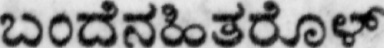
ಬಂದೆನಹಿತರೊಳ್
